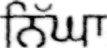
ਨਿੱਘਾ
